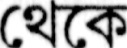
থেকে
